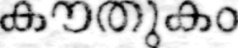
കൌതുകം
